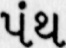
પંથ
